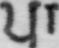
ਪਾ
